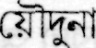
য়ৌদুনা
